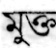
মুক্ত
